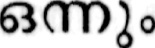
ഒന്നും
